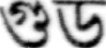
গুড
